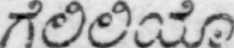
ಗೆಲಿಲಿಯೊ
